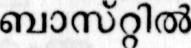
ബാസ്റ്റില്‍
